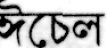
ঈচেল
